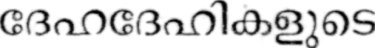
ദേഹദേഹികളുടെ
